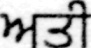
ਅਤੀ
